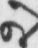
જે
